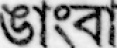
ঙাংবা
